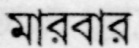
মারবার
